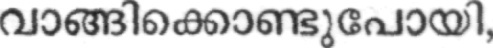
വാങ്ങിക്കൊണ്ടുപോയി,
